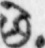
છે.
